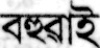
বহুৱাই
